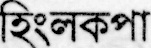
হিংলকপা
